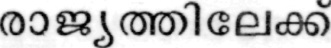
രാജ്യത്തിലേക്ക്
